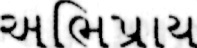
અભિપ્રાય
